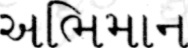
અભિમાન
